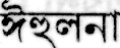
ঈহুলনা
